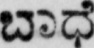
ಬಾಧೆ
